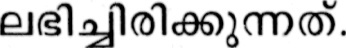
ലഭിച്ചിരിക്കുന്നത്.
